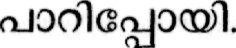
പാറിപ്പോയി.
